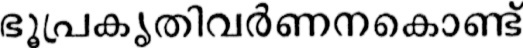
ഭൂപ്രകൃതിവര്‍ണനകൊണ്ട്
